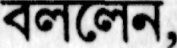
বললেন,
